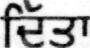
ਦਿੱਤਾ
